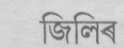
জিলিৰ
